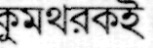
কুমথরকই
